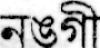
নঙগী
